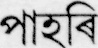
পাহৰি
